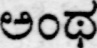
ಅಂಥ
